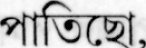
পাতিছো,
